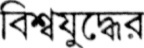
বিশ্বযুদ্ধের
